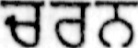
ਚਰਨ
